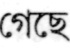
গেছে
